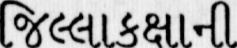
જિલ્લાકક્ષાની
